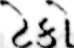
ટેકો
